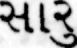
સારુ
